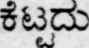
ಕೆಟ್ಟದು
